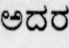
ಅದರ
